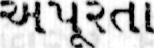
અપૂરતા
